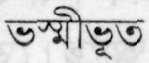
ভস্মীভূত
